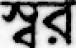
স্বর
